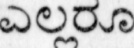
ಎಲ್ಲರೂ
